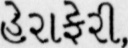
હેરાફેરી,
